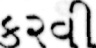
કરવી
